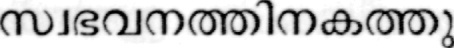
സ്വഭവനത്തിനകത്തു
